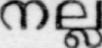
നല്ല
